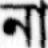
না
